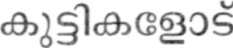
കുട്ടികളോട്
